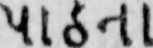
પાઠના
